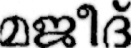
മജീദ്
